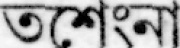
তশেংনা
